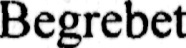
Begrebet
